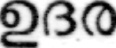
ഉദര
